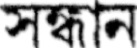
সন্ধান
